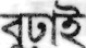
বুঢ়াই
